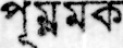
পূম্নমক
